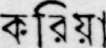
করিয়া
